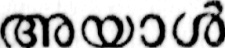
അയാള്‍
